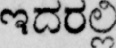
ಇದರಲ್ಲಿ
